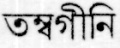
তম্বগীনি
